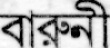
বারুনী
